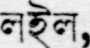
লইল,
